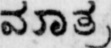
ಮಾತ್ರ
